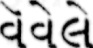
વૅવેલે
